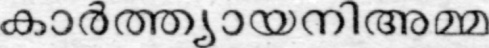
കാര്‍ത്ത്യായനിഅമ്മ
